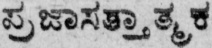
ಪ್ರಜಾಸತ್ತಾತ್ಮಕ
